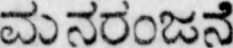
ಮನರಂಜನೆ
